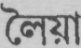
লৈয়া
